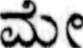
ಮೇ
